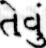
તેવું
